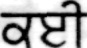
ਕਈ
